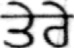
ਤੇਰੇ
